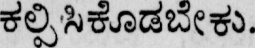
ಕಲ್ಪಿಸಿಕೊಡಬೇಕು.
